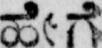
ಹೇಗೆ
